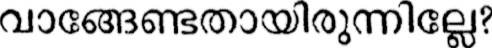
വാങ്ങേണ്ടതായിരുന്നില്ലേ?
